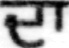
ਦਾ
